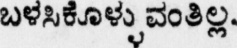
ಬಳಸಿಕೊಳ್ಳುವಂತಿಲ್ಲ.
